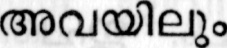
അവയിലും
